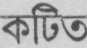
কটিত
